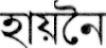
হায়নৈ
